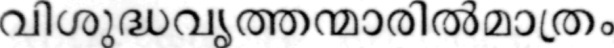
വിശുദ്ധവൃത്തന്മാരില്‍മാത്രം
